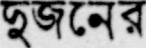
দুজনের
